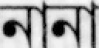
নানা
